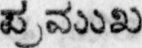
ಪ್ರಮುಖ
